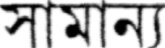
সামান্য
